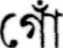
গোঁ
